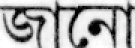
জানো
